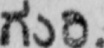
ಗುರಿ.
